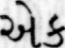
એક
